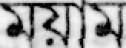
ময়াম
